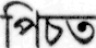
পিচত
